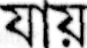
যায়
